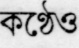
কণ্ঠেও
